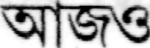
আজও
